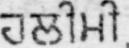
ਹਲੀਮੀ
